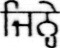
ਜਿਨ੍ਹੇ
